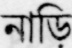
নাড়ি
